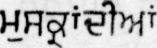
ਮੁਸਕ੍ਰਾਂਦੀਆਂ
